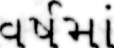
વર્ષમાં
